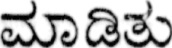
ಮಾಡಿತು
